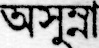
অসুম্না
